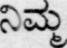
ನಿಮ್ಮ
